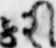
કરી
